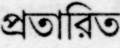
প্রতারিত
